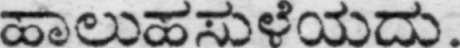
ಹಾಲುಹಸುಳೆಯದು.
